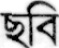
ছবি
